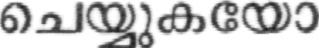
ചെയ്യുകയോ
